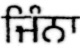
ਜਿੰਨਾ
